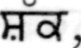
ਸ਼ੱਕ,
